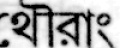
থৌরাং
